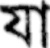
যা
